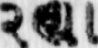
રહ્યા
